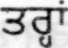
ਤਰ੍ਹਾਂ
